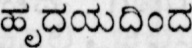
ಹೃದಯದಿಂದ
